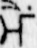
ਮੈਂ
